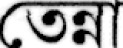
তেন্না
